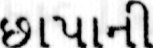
છાપાની
